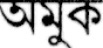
অমুক
